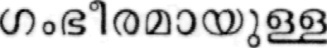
ഗംഭീരമായുള്ള
